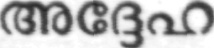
അദ്ദേഹ
